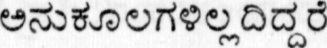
ಅನುಕೂಲಗಳಿಲ್ಲದಿದ್ದರೆ
